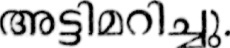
അട്ടിമറിച്ചു.
